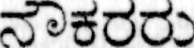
ನೌಕರರು
